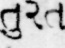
તુરત
